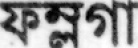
ফম্লগা
